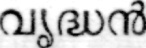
വൃദ്ധന്‍
